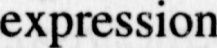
expression
